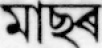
মাছৰ
